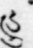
હું
